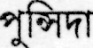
পুন্সিদা
